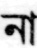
না
